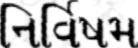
નિર્વિષમ
